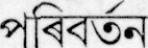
পৰিবর্তন
